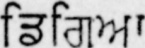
ਡਿਗਿਆ
